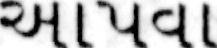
આપવા
